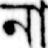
না
